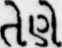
તેણે
